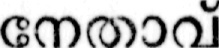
നേതാവ്
